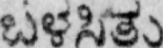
ಬಳಸಿತು
